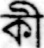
কী
